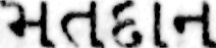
મતદાન
